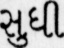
સુધી
